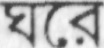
ঘরে
